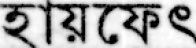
হায়ফেৎ
